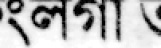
ফংলগা
